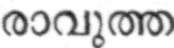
രാവുത്ത
